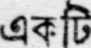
একটি
